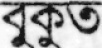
বুকুত
